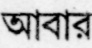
আবার
